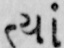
ત્યાં
